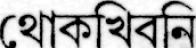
থোকখিবনি
